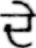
ਦੇ
